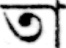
তা
